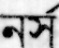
নর্স
